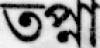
তপ্না
